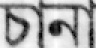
চানা
